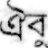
ঐবু
